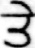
ਤੇ
